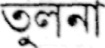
তুলনা
